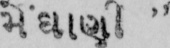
મેંઘાણી"
